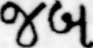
જબ
